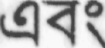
এবং
